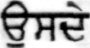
ਉਸਦੇ
